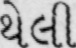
થેલી
